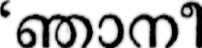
'ഞാനീ
